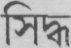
সিদ্ধ
